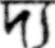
দ্য
